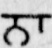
ਨਾ
